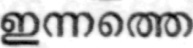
ഇന്നത്തെ
